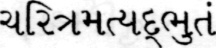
ચરિત્રમત્યદ્ભુતં
